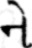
ને
